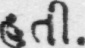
હતી.
